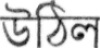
উঠিল
